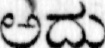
ಅದು
